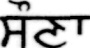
ਸੌਣਾ
